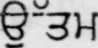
ਉੱਤਮ
